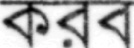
করব
